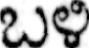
ಬಳಿ
